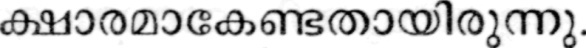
ക്ഷാരമാകേണ്ടതായിരുന്നു.
